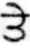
ਤੇ
